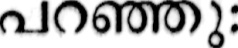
പറഞ്ഞു:
